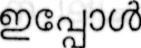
ഇപ്പോള്‍
